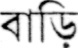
বাড়ি
